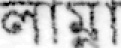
লাম্না
